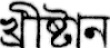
খ্ৰীষ্টান
